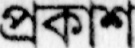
প্রকাশ
